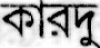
কারদু
